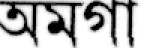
অমগা
